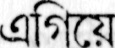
এগিয়ে
